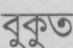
বুকুত
